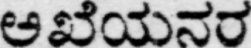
ಅಖೆಯನರ
